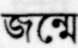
জন্মে
